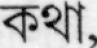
কথা,
